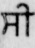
ਸੀ
